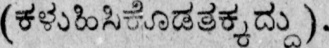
(ಕಳುಹಿಸಿಕೊಡತಕ್ಕದ್ದು).
